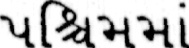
પશ્ચિમમાં
